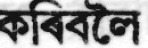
কৰিবলৈ
